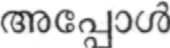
അപ്പോള്‍
